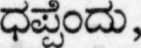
ಧಪ್ಪೆಂದು,
